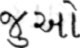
જુઓ
